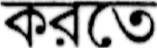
করতে
